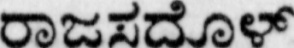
ರಾಜಸದೊಳ್
